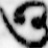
ও
